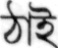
ঠাই
